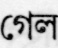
গেল
